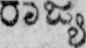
ರಾಜ್ಯ
